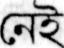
নেই
